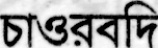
চাওরবদি
